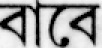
বাবে
